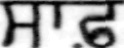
ਸਾਫ਼
